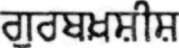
ਗੁਰਬਖ਼ਸ਼ੀਸ਼
